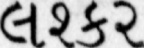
લશ્કર
